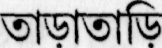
তাড়াতাড়ি
